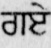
ਗਏ
